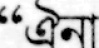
“ঐনা
